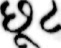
છૂટ
